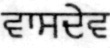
ਵਾਸਦੇਵ
